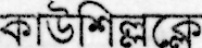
কাউশিল্লক্লে
